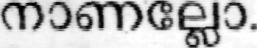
നാണല്ലോ.
